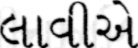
લાવીએ
